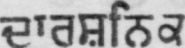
ਦਾਰਸ਼ਨਿਕ
